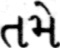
તમે
